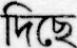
দিছে
